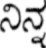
ನಿನ್ನ
